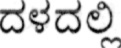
ದಳದಲ್ಲಿ
